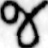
જ
